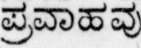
ಪ್ರವಾಹವು
